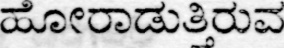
ಹೋರಾಡುತ್ತಿರುವ
